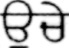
ਉਚੇ
